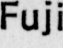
Fuji
